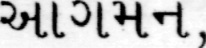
આગમન,
